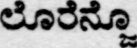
ಲೊರೆನ್ಜೊ
